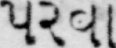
પરવા
